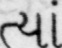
ત્યાં
